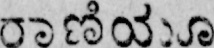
ರಾಣಿಯೂ
